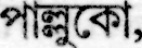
পাল্লুকো,
